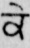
ਕੇ
